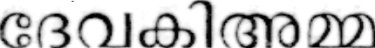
ദേവകിഅമ്മ
